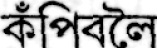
কঁপিবলৈ
